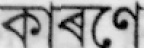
কাৰণে
